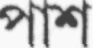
পাশ
